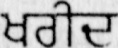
ਖਰੀਦ
